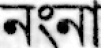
নংনা
